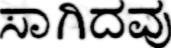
ಸಾಗಿದವು
